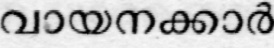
വായനക്കാര്‍
